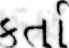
કર્તા
